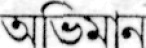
অভিমান
